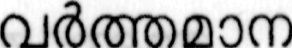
വര്‍ത്തമാന
